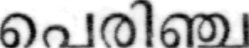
പെരിഞ്ച
